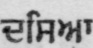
ਦਸਿਆ
